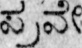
ಪ್ರವೇ
